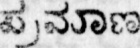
ಪ್ರಮಾಣ
